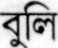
বুলি
